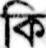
কি
